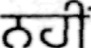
ਨਹੀਂ
